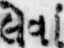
લેવાં
